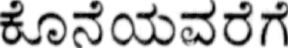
ಕೊನೆಯವರೆಗೆ
